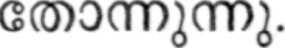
തോന്നുന്നു.
